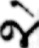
જે
